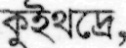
কুইথদ্রে,
